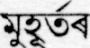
মুহূর্তৰ
